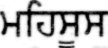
ਮਹਿਸੂਸ
